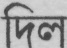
দিল
